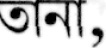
তানা,
